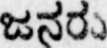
ಜನರು
